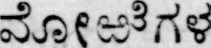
ಮೋಱೆಗಳ
